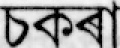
চকৰা
